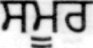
ਸਮੂਰ
